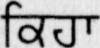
ਕਿਹਾ
